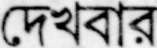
দেখবার
